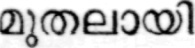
മുതലായി
